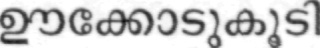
ഊക്കോടുകൂടി
